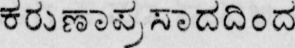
ಕರುಣಾಪ್ರಸಾದದಿಂದ
